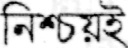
নিশ্চয়ই
